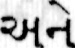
અને
